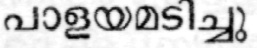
പാളയമടിച്ചു
